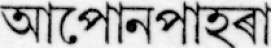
আপোনপাহৰা
